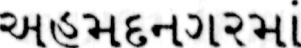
અહમદનગરમાં
